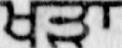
ਖੜਾ
